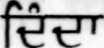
ਦਿੰਦਾ
